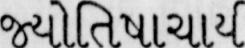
જ્યોતિષાચાર્ય
